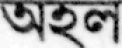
অহল
